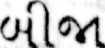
બીજા
